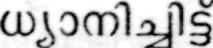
ധ്യാനിച്ചിട്ട്
